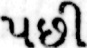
પછી
